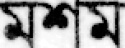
মশম
